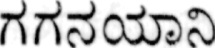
ಗಗನಯಾನಿ
